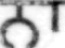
ਨਾ
